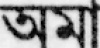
অমা
